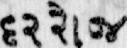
દરરોજ
